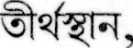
তীর্থস্থান,
